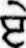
ਏ
